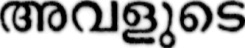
അവളുടെ
